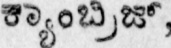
ಕ್ಯಾಂಬ್ರಿಜ್,
